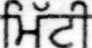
ਮਿੱਟੀ
